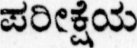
ಪರೀಕ್ಷೆಯ
